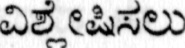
ವಿಶ್ಲೇಷಿಸಲು
